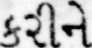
કરીને
